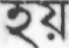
হয়
